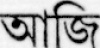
আজি
